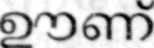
ഊണ്
